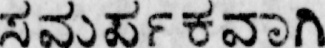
ಸಮರ್ಪಕವಾಗಿ
